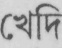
খেদি
